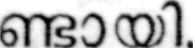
ണ്ടായി.
